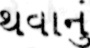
થવાનું
